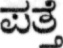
ಪತ್ತೆ
